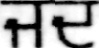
ਜਦ
